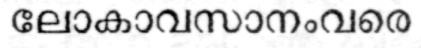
ലോകാവസാനംവരെ
